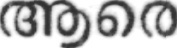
ആരെ
